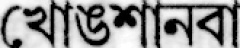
খোঙশানবা
